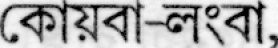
কোয়বা-লংবা,
